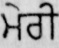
ਮੇਰੀ
